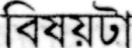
বিষয়টা
